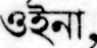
ওইনা,
